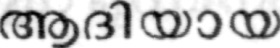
ആദിയായ
